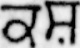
ਕਸ਼
